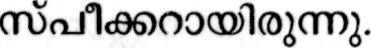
സ്പീക്കറായിരുന്നു.
